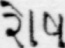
રોષ
